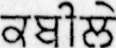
ਕਬੀਲੇ
